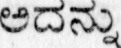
ಅದನ್ನು
